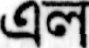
এল
